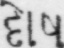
દોષ
